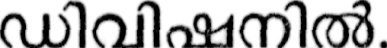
ഡിവിഷനില്‍.
